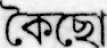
কৈছো
